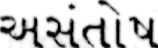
અસંતોષ
